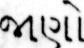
જાણો
